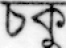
চকু
